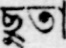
ছুতা
